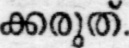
ക്കരുത്.
